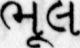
ભૂલ
